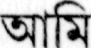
আমি
